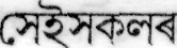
সেইসকলৰ
